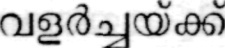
വളര്‍ച്ചയ്ക്ക്
